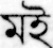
মই
